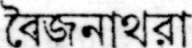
বৈজনাথরা
